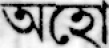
অহো
